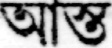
আস্ত
